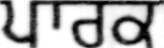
ਪਾਰਕ
